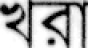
খরা
